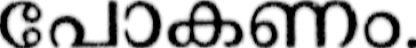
പോകണം.
